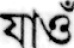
যাওঁ
